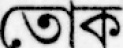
তোক
